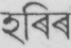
হৰিৰ
